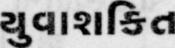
યુવાશક્તિ
